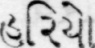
હરિયો
